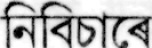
নিবিচাৰে
